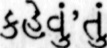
કહેવું'તું
